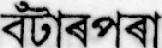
বঁটাৰপৰা
